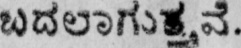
ಬದಲಾಗುತ್ತವೆ.
